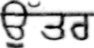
ਉੱਤਰ
